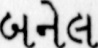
બનેલ
